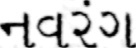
નવરંગ
